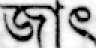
জাৎ
